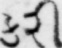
કરી
